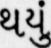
થયું
